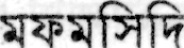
মফমসিদি
